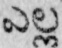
ಎಲ್ಲ
